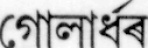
গোলার্ধৰ
